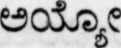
ಅಯ್ಯೋ
